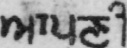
ਆਪਣੀ
